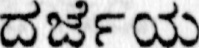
ದರ್ಜೆಯ
